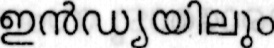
ഇന്‍ഡ്യയിലും
